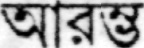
আরম্ভ
